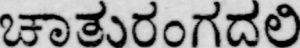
ಚಾತುರಂಗದಲಿ
